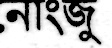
নোংজু
